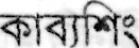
কাব্যশিং
